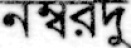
নম্বরদু
